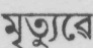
মৃত্যুৱে
